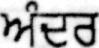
ਅੰਦਰ
